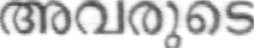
അവരുടെ
